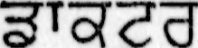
ਡਾਕਟਰ
